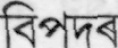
বিপদৰ
